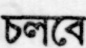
চলবে
